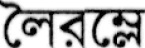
লৈরম্লে
